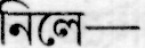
নিলে-
